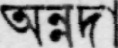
অন্নদা
